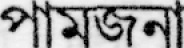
পামজনা
